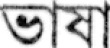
ভাষা
